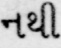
નથી
